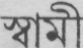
স্বামী
